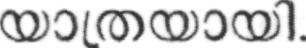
യാത്രയായി.
